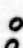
ঃ
